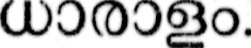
ധാരാളം.
